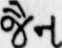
જૈન
